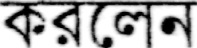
করলেন
